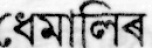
ধেমালিৰ
